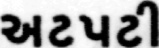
અટપટી
